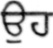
ਉਹ
